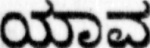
ಯಾವ
